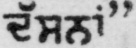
ਦੱਸਨਾਂ''
